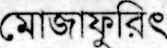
মোজাফুরিৎ
